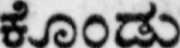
ಕೊಂಡು
